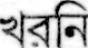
খরনি
